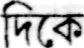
দিকে
